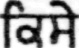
ਕਿਸੇ
